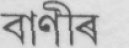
বাণীৰ
